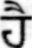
ਹੈ
